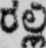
ರಲ್ಲಿ
